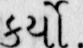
કર્યો.
